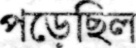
পড়েছিল
